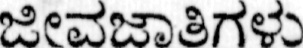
ಜೀವಜಾತಿಗಳು
